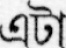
এটা
